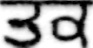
ਤਕ
